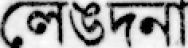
লেঙদনা
